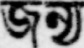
জন্য
